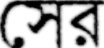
সের
